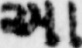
આ
